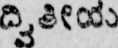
ದ್ವಿತೀಯ
